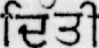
ਦਿੱਤੀ
